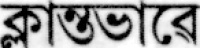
ক্লান্তভাৱে
